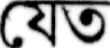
যেত
